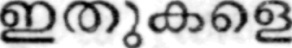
ഇതുകളെ
